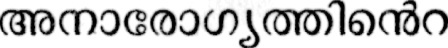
അനാരോഗ്യത്തിന്റെ
